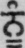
ਨੂੰ
